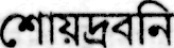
শোয়দ্রবনি
